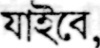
যাইবে,
